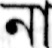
না
